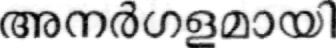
അനര്‍ഗളമായി
